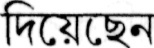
দিয়েছেন
